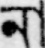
না
